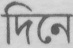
দিনে
